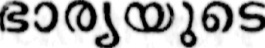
ഭാര്യയുടെ
